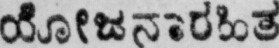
ಯೋಜನಾರಹಿತ
